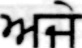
ਅਜੇ
